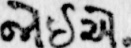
જોઈએ.
